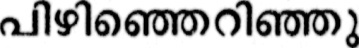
പിഴിഞ്ഞെറിഞ്ഞു
